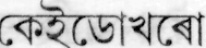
কেইডোখৰো
